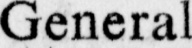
General
